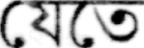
যেতে
